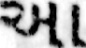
આ
